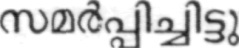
സമര്‍പ്പിച്ചിട്ടു
